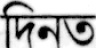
দিনত
